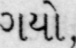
ગયો,
